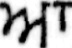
ਆ
